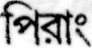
পিরাং
